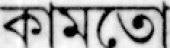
কামতো
